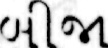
બીજા
